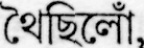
থৈছিলোঁ,
